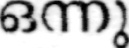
ഒന്നു
